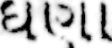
ઘણા
